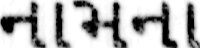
નામના
